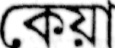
কেয়া
